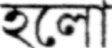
হলো
